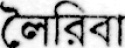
লৈরিবা
